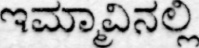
ಇಮ್ಮಾವಿನಲ್ಲಿ
